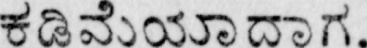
ಕಡಿಮೆಯಾದಾಗ.
